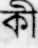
কী
